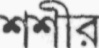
শশীর
